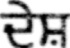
ਦੇਸ਼
